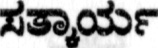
ಸತ್ಕಾರ್ಯ
